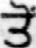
ਤੋਂ
